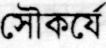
সৌকর্যে
